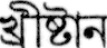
খ্ৰীষ্টান
